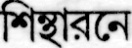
শিন্থারনে
